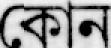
কোন
